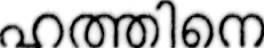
ഹത്തിനെ
